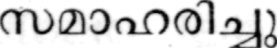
സമാഹരിച്ചു
